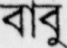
বাবু
